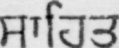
ਸਾਹਿਤ
